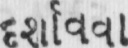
દર્શાવવા
